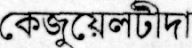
কেজুয়েলটিদা
